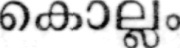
കൊല്ലം
